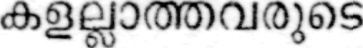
കളല്ലാത്തവരുടെ
